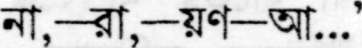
না,—রা,—য়ণ—আ...’
